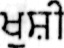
ਖੁਸ਼ੀ
